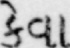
કેવા
